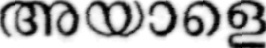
അയാളെ
